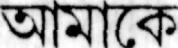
আমাকে
